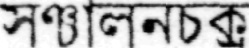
সঞ্চালনচক্র
